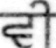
ਵੀ
